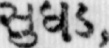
સુઘડ,
